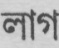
লাগ
